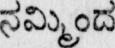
ನಮ್ಮಿಂದ
